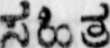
ಸಹಿತ
